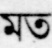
মত
